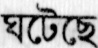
ঘটেছে
